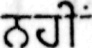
ਨਹੀਂ
